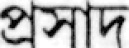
প্রসাদ
